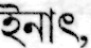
ইনাৎ,
